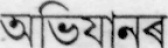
অভিযানৰ
